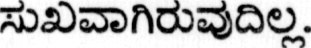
ಸುಖವಾಗಿರುವುದಿಲ್ಲ.
